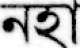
নহা
